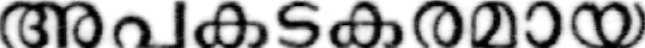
അപകടകരമായ
